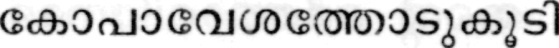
കോപാവേശത്തോടുകൂടി
